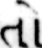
તો
